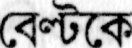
বেল্টকে
